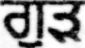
ਗੁੜ
